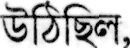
উঠিছিল,
